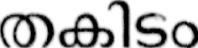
തകിടം
